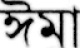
ঈমা
